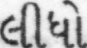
લીધો
